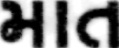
માત
